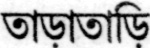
তাড়াতাড়ি
